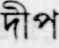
দীপ
